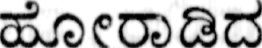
ಹೋರಾಡಿದ
